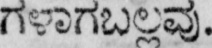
ಗಳಾಗಬಲ್ಲವು.
